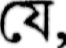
যে,
